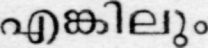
എങ്കിലും
